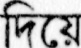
দিয়ে
